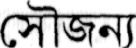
সৌজন্য
